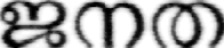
ജനത
